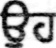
ਉਹ
